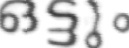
ഒട്ടും
